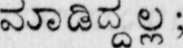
ಮಾಡಿದ್ದಲ್ಲ;
